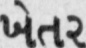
ખેતર
